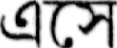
এসে
